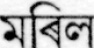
মৰিল
